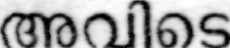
അവിടെ
